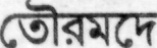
তৌরমদে
